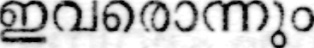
ഇവരൊന്നും
